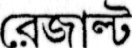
রেজাল্ট
